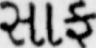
સાફ
